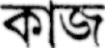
কাজ
